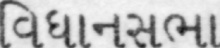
વિધાનસભા
